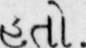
હતો.
